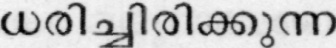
ധരിച്ചിരിക്കുന്ന
